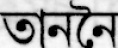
তাননৈ
